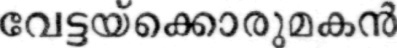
വേട്ടയ്ക്കൊരുമകന്‍
